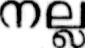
നല്ല
